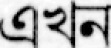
এখন
